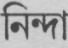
নিন্দা
